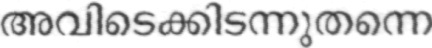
അവിടെക്കിടന്നുതന്നെ
